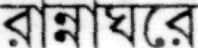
রান্নাঘরে
